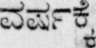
ವರ್ಷಕ್ಕೆ
